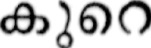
കുറെ
